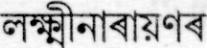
লক্ষ্মীনাৰায়ণৰ
